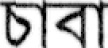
চাবা
